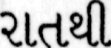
રાતથી
